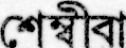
শেম্বীবা
